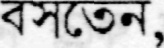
বসতেন,
